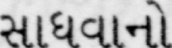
સાધવાનો
